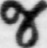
જ
